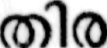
തിര
